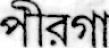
পীরগা
